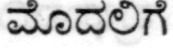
ಮೊದಲಿಗೆ
